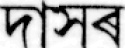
দাসৰ
